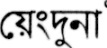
য়েংদুনা
